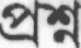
প্রশ্ন
